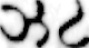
ઝટ
